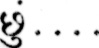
છું....
